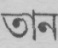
তান
